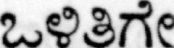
ಒಳಿತಿಗೇ
